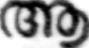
ആ
